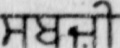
ਸਬਜ਼ੀ
